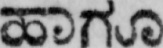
ಹಾಗೂ
